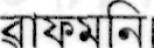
ৱাফমনি।
